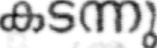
കടന്നു
